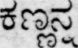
ಕಣ್ಣನ್ನ
